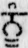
ਨੂੰ
